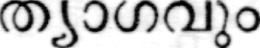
ത്യാഗവും
